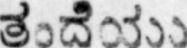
ತಂದೆಯು
